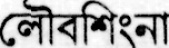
লৌবশিংনা
